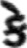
કે
